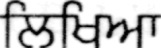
ਲਿਖਿਆ
